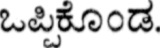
ಒಪ್ಪಿಕೊಂಡ.
